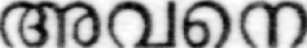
അവനെ
